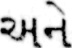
અને
